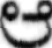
ಆ
